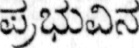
ಪ್ರಭುವಿನ
